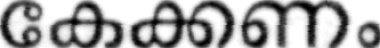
കേക്കണം
